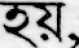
হয়,
